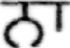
ਨਾ
